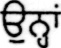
ਉਨ੍ਹਾਂ
